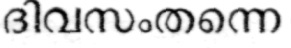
ദിവസംതന്നെ
